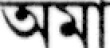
অমা
